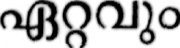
ഏറ്റവും
